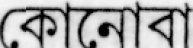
কোনোবা
